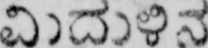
ಮಿದುಳಿನ
